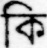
কি
